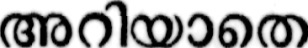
അറിയാതെ
